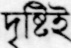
দৃষ্টিই
